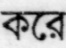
করে
